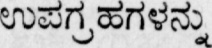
ಉಪಗ್ರಹಗಳನ್ನು
